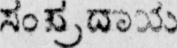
ಸಂಪ್ರದಾಯ
